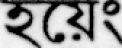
হয়েং
